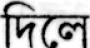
দিলে
